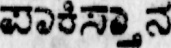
ಪಾಕಿಸ್ತಾನ
